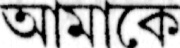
আমাকে
